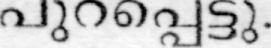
പുറപ്പെട്ടു.
